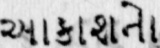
આકાશનો
